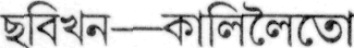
ছবিখন-কালিলৈতো
